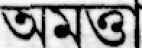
অমত্তা
